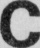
C
